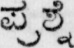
ಪ್ರಶ್ನೆ
